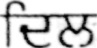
ਦਿਲ
